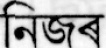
নিজৰ
